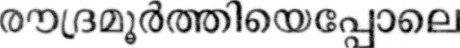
രൌദ്രമൂര്‍ത്തിയെപ്പോലെ
